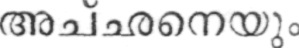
അച്ഛനെയും
